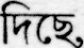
দিছে,
